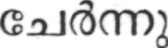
ചേര്‍ന്നു
